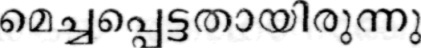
മെച്ചപ്പെട്ടതായിരുന്നു
